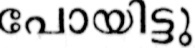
പോയിട്ടു
